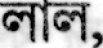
লাল,
